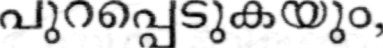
പുറപ്പെടുകയും,
